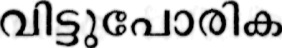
വിട്ടുപോരിക
